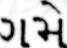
ગમે
